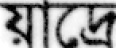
য়াদ্রে
